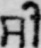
ਸੀ
